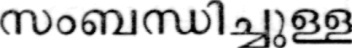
സംബന്ധിച്ചുള്ള
